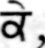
ਕੇ,
